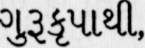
ગુરૂકૃપાથી,
